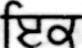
ਇਕ
